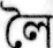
লৈ
